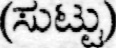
(ಸುಟ್ಟು)
